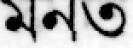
মনত
